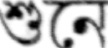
শুনে
